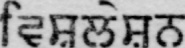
ਵਿਸ਼ਲੇਸ਼ਨ
